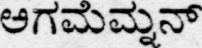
ಅಗಮೆಮ್ನನ್
